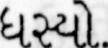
ધસ્યો.
